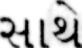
સાથે
